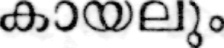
കായലും
